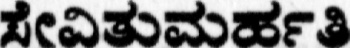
ಸೇವಿತುಮರ್ಹತಿ
